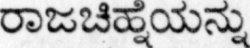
ರಾಜಚಿಹ್ನೆಯನ್ನು
